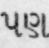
પણ
